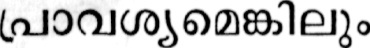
പ്രാവശ്യമെങ്കിലും
